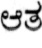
ಆತ
